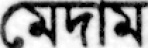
মেদাম
